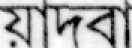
য়াদবা
